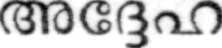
അദ്ദേഹ
